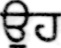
ਉਹ
